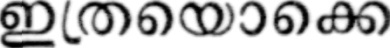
ഇത്രയൊക്കെ
